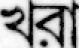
খরা
